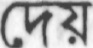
দেয়
